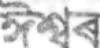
ঈশ্বৰ
